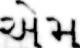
એમ
